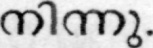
നിന്നു.
